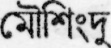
মৌশিংদু
